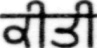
ਕੀਤੀ
